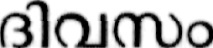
ദിവസം
